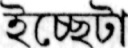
ইচ্ছেটা
